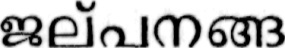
ജല്പനങ്ങ
